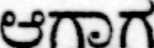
ಆಗಾಗ
